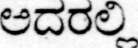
ಅದರಲ್ಲಿ
